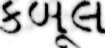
કબૂલ
